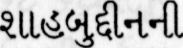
શાહબુદ્દીનની
